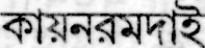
কায়নরমদাই
